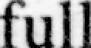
full
